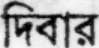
দিবার
